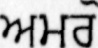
ਅਮਰੋ
